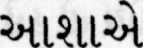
આશાએ
